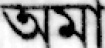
অমা
